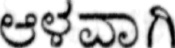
ಆಳವಾಗಿ
